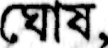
ঘোষ,
